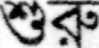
শুরু
